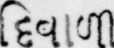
દિવાળી
